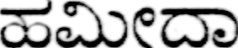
ಹಮೀದಾ
